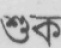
শুক
